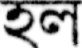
হল
